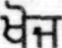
ਖੋਜ
